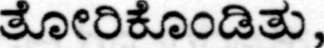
ತೋರಿಕೊಂಡಿತು,
